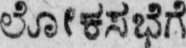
ಲೋಕಸಭೆಗೆ
